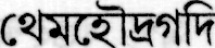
থেমহৌদ্রগদি
